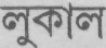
লুকাল
